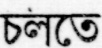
চলতে
